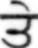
ਤੇ
